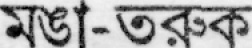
মঙা-তরুক
